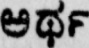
ಅರ್ಥ
